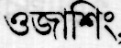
ওজাশিং,
